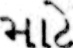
માટે
